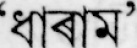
'ধাৰাম'
